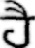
ਹੈ
